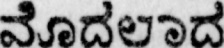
ಮೊದಲಾದ
